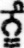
ਨੂੰ
